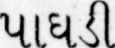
પાઘડી
